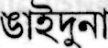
ঙাইদুনা
